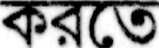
করতে
